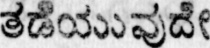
ತಡೆಯುವುದೇ
